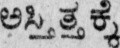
ಅಸ್ತಿತ್ತಕ್ಕೆ
